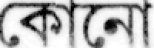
কোনো
